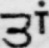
ਤਾਂ
